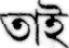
তাই
